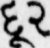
દૂર
